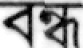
বন্ধ
